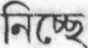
নিচ্ছে
